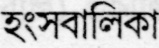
হংসবালিকা
